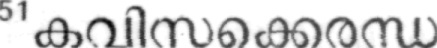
51കവിസക്കെരന്ധ
